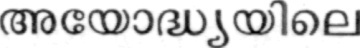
അയോദ്ധ്യയിലെ
